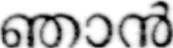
ഞാന്‍
